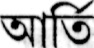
আর্তি
